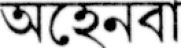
অহেনবা
